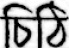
চিঠি
